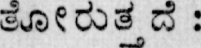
ತೋರುತ್ತದೆ:
